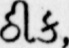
ઠીક,
